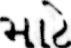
માટે
